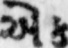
એક
